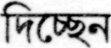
দিচ্ছেন
